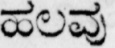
ಹಲವು
